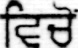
ਵਿਚੋਂ
